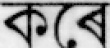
কৰে
